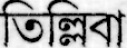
তিল্লিবা
